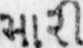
મારી
